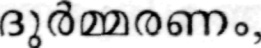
ദുര്‍മ്മരണം,
